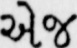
એજ
